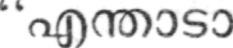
"എന്താടാ
